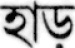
হাড়
